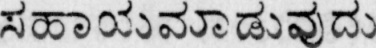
ಸಹಾಯಮಾಡುವುದು
